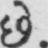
છે.
